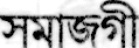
সমাজগী
